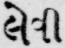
લેવી
